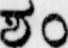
ಶಂ
